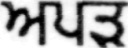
ਅਪੜ
